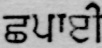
ਛਪਾਈ
